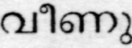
വീണു
